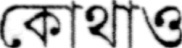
কোথাও
